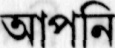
আপনি
